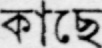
কাছে
